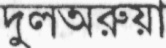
দুলঅরুয়া
